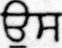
ਉਸ
